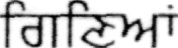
ਗਿਣਿਆਂ
